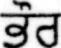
ਭੌਰ
